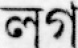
লগ
